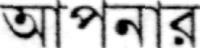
আপনার
